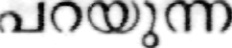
പറയുന്ന
